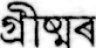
গ্ৰীষ্মৰ
